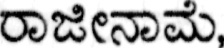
ರಾಜೀನಾಮೆ,
